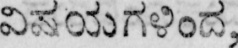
ವಿಷಯಗಳಿಂದ,
